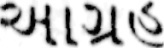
આગ્રહ
